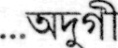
...অদুগী
